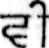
ਵੀ
